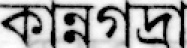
কান্নগদ্রা
